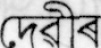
দেৱীৰ
